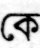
কে
